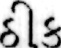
ઠીક
